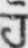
ਹੋ
